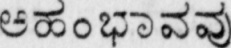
ಅಹಂಭಾವವು
